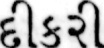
દીકરી
